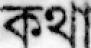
কথা
